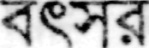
বৎসর
